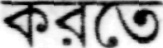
করতে
